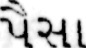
પૈસા
